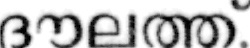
ദൌലത്ത്.
